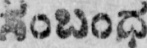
ಸಂಬಂಧ
